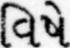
વિષે
